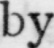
by
